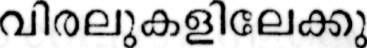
വിരലുകളിലേക്കു
